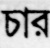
চার
